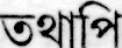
তথাপি
